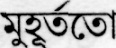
মুহূর্ততো
